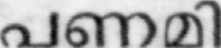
പണമി
